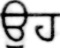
ਉਹ
